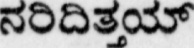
ನರಿದಿತ್ತಯ್
